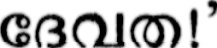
ദേവത!’
